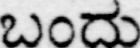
ಬಂದು
